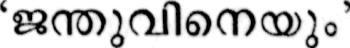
‘ജന്തുവിനെയും'
